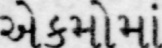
એકમોમાં
